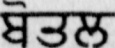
ਬੋਤਲ
